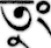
তুং
